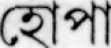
হোপা
